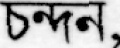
চন্দন,
